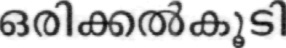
ഒരിക്കല്‍കൂടി
